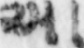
આ
